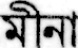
মীনা
